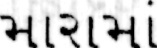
મારામાં
